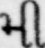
મી
